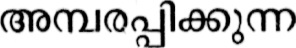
അമ്പരപ്പിക്കുന്ന
